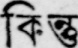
কিন্তু
